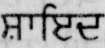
ਸ਼ਾਇਦ
